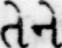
તેને
